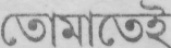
তোমাতেই
